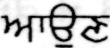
ਆਉਣ
